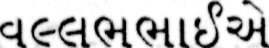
વલ્લભભાઈએ
